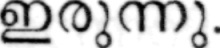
ഇരുന്നു.
